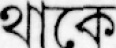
থাকে
